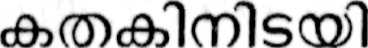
കതകിനിടയി
